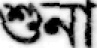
শুনা
